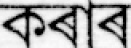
কৰাৰ
